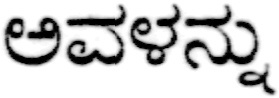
ಅವಳನ್ನು
